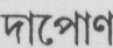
দাপোণ
